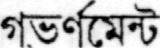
গভর্ণমেন্ট
